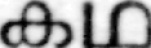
കഥ
